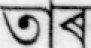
তাৰ
